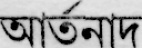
আর্তনাদ
